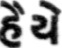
હૈયે
